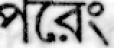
পরেং
